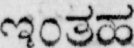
ಇಂತಹ
